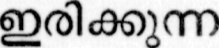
ഇരിക്കുന്ന
